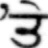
'ਤੇ
